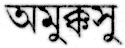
অমুক্কসু
